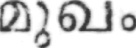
മുഖം
